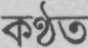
কণ্ঠত
